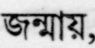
জন্মায়,
